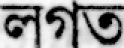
লগত
